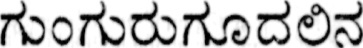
ಗುಂಗುರುಗೂದಲಿನ
